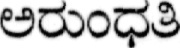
ಅರುಂಧತಿ
